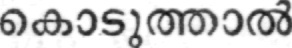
കൊടുത്താല്‍
